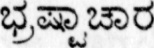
ಭ್ರಷ್ಟಾಚಾರ
